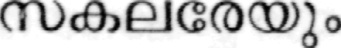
സകലരേയും
